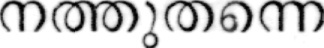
നത്തുതന്നെ
